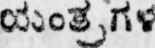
ಯಂತ್ರಗಳ
